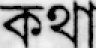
কথা
